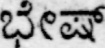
ಭೇಷ್
